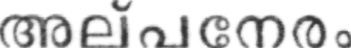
അല്പനേരം
